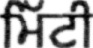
ਮਿੱਟੀ
